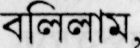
বলিলাম,
